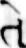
તે
